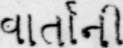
વાર્તાની
